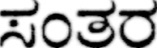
ಸಂತರ
